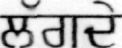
ਲੱਗਦੇ
